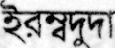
ইরম্বদুদা
